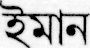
ইমান
